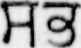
ਸਭ
